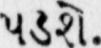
પડશે.
